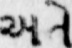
અને
